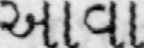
આવા
